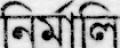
নির্মালি
